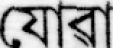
যোৱা
